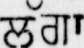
ਲੱਗਾ
